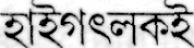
হাইগৎলকই
